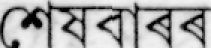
শেষবাৰৰ
